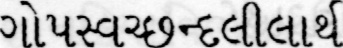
ગોપસ્વચ્છન્દલીલાર્થ
